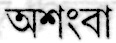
অশংবা
